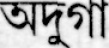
অদুগা
